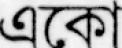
একো
